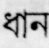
ধান
